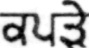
ਕਪੜੇ
